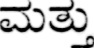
ಮತ್ತು
